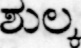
ಶುಲ್ಕ
